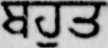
ਬਹੁਤ
